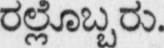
ರಲ್ಲೊಬ್ಬರು.
